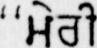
''ਮੇਰੀ
